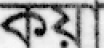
কয়া
